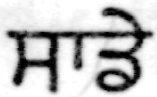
ਸਾਡੇ
